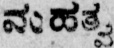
ಮಹತ್ವ
